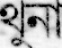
থুনা
